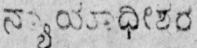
ನ್ಯಾಯಾಧೀಶರ
